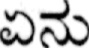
ಏನು
